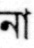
না
